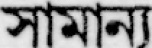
সামান্য
